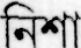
নিশা
